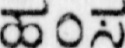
ಹಂಸ
